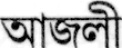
আজলী
